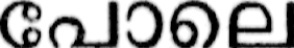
പോലെ
